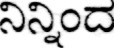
ನಿನ್ನಿಂದ
